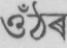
ওঁঠৰ
